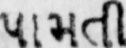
પામતી
